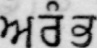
ਅਰੰਭ
